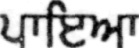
ਪਾਇਆ
